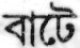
বাটে
